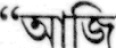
"আজি
